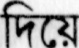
দিয়ে
